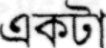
একটা
